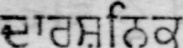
ਦਾਰਸ਼ਨਿਕ
